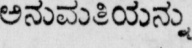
ಅನುಮತಿಯನ್ನು
